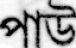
পাউ
